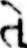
તે
